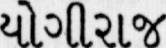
યાગીરાજ
